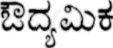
ಔದ್ಯಮಿಕ
